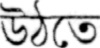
উঠতে
